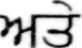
ਅਤੇ
